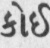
કોઈ
